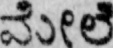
ಮೇಲೆ
